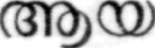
ആയ
